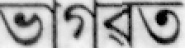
ভাগৱত
